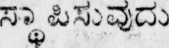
ಸ್ಥಾಪಿಸುವುದು
